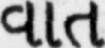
વાત
